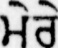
ਮੇਰੇ
